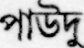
পাউদু
